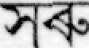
সৰু
